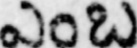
ಎಂಬ
